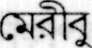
মেরীবু
